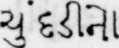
ચુંદડીનો
